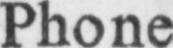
Phone
